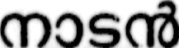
നാടന്‍
